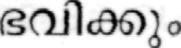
ഭവിക്കും
